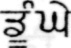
ਡੂੰਘੇ
